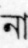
না
